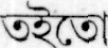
তইতো
